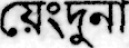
য়েংদুনা
